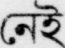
নেই
